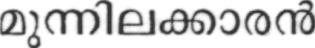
മുന്നിലക്കാരന്‍
